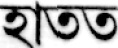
হাতত
